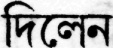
দিলেন
